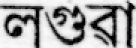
লগুৱা
